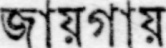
জায়গায়
